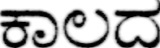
ಕಾಲದ
